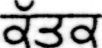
ਕੱਤਕ
